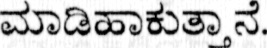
ಮಾಡಿಹಾಕುತ್ತಾನೆ.
